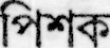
পিশক
